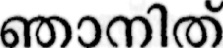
ഞാനിത്
